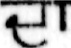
ਦਾ
